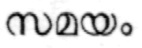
സമയം
